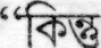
"কিন্তু
